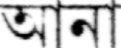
আনা
